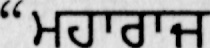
''ਮਹਾਰਾਜ
